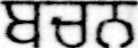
ਬਚਨ
